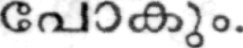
പോകും.
